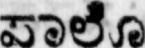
ಪಾಲೊ
